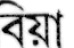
বিয়া
